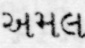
અમલ
